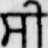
ਸੀ
